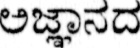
ಅಜ್ಞಾನದ
